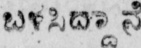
ಬಳಸಿದ್ದಾನೆ
